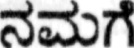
ನಮಗೆ
